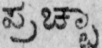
ಪ್ರಚ್ಛಾ
